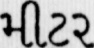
મીટર
